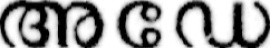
അഡേ
